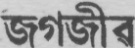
জগজীৱ
